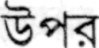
উপর
